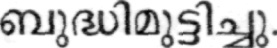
ബുദ്ധിമുട്ടിച്ചു.
